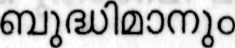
ബുദ്ധിമാനും
